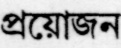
প্রয়োজন
